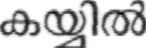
കയ്യില്‍
